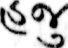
હજુ
